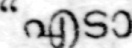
“എടാ
